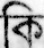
কি
